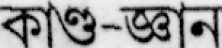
কাণ্ড-জ্ঞান
